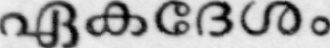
ഏകദേശം
